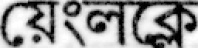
য়েংলক্লে
